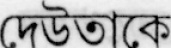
দেউতাকে
